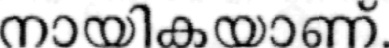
നായികയാണ്.
